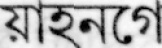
য়াহনগে
